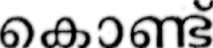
കൊണ്ട്
